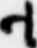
ન
